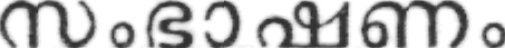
സംഭാഷണം
